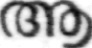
ആ
